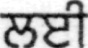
ਲਈ
